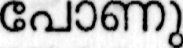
പോണു
